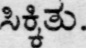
ಸಿಕ್ಕಿತು.
